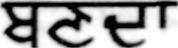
ਬਣਦਾ
